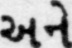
અને
